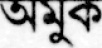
অমুক
